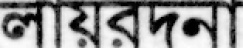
লায়রদনা
